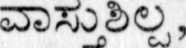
ವಾಸ್ತುಶಿಲ್ಪ,
